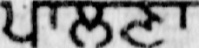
ਪਾਲਣਾ
